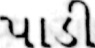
પાડી
